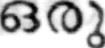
ഒരു
